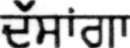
ਦੱਸਾਂਗਾ
